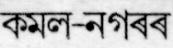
কমল-নগৰৰ
